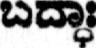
ಬದ್ದಾಃ
